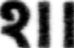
શા
